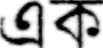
এক
